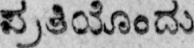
ಪ್ರತಿಯೊಂದು
